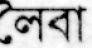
লৈবা
